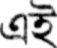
এই
